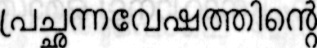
പ്രച്ഛന്നവേഷത്തിന്റെ
